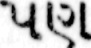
પણ
